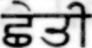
ਛੇਤੀ
